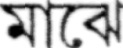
মাঝে
